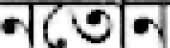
নতোন
